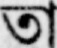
তা
